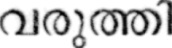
വരുത്തി
